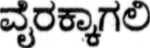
ವೈರಕ್ಕಾಗಲಿ
